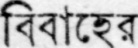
বিবাহের
